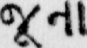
જૂના
